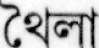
থৈলা
